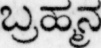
ಬ್ರಹ್ಮನ
